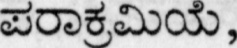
ಪರಾಕ್ರಮಿಯೆ,
